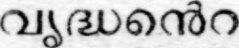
വൃദ്ധന്റെ
